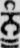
ਨੂੰ
